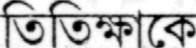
তিতিক্ষাকে
